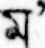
ম’
